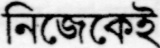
নিজেকেই
